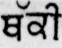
ਥੱਕੀ
